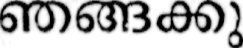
ഞങ്ങക്കു
